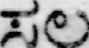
ಸಲ
